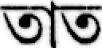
তাত
